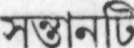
সন্তানটি
